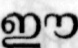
ഈ
